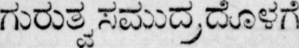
ಗುರುತ್ವಸಮುದ್ರದೊಳಗೆ
